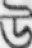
উ
